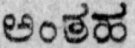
ಅಂತಹ
